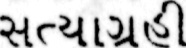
સત્યાગ્રહી
